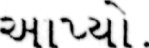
આપ્યો.
